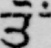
ਤੋਂ
